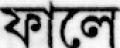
ফালে
